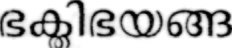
ഭക്തിഭയങ്ങ
